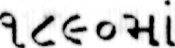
૧૮૯૦માં
